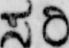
ಸರಿ
